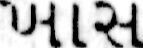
ખાસ
